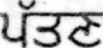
ਪੱਤਣ
